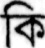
কি
